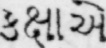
કક્ષાએ
